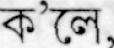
ক'লে,
